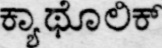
ಕ್ಯಾಥೊಲಿಕ್
